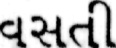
વસતી
